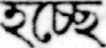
হচ্ছে
